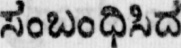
ಸಂಬಂಧಿಸಿದ
